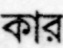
কার
